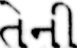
તેની
